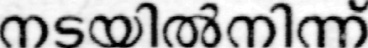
നടയില്‍നിന്ന്
